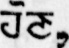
ਹੋਣ,
